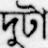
দুটা
